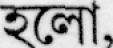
হলো,
